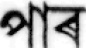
পাৰ
